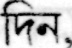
দিন,
